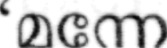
'മന്നേ
